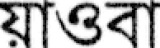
য়াওবা
